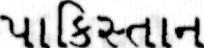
પાકિસ્તાન
